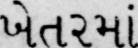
ખેતરમાં
